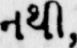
નથી,
